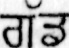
ਗੱਡ
